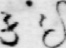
કંઈ
